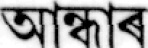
আন্ধাৰ
